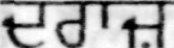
ਦਰਾਜ਼
